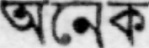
অনেক
